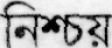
নিশ্চয়
